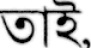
তাই,
